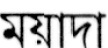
ময়াদা
